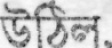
উঠিল,
